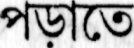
পড়াতে
